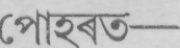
পোহৰত-
